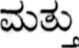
ಮತ್ತು
